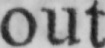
out
